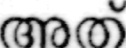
അത്
